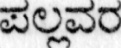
ಪಲ್ಲವರ
